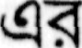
এর
